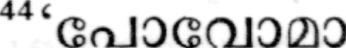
44'പോവോമാ
